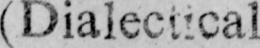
(Dialectical
